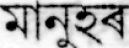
মানুহৰ
